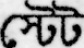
স্টেট
